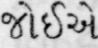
જોઈએ
